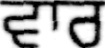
ਵਾਰ
